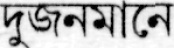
দুজনমানে
